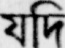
যদি
